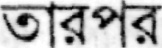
তারপর
